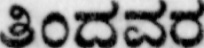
ತಿಂದವರ
